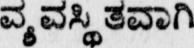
ವ್ಯವಸ್ಥಿತವಾಗಿ
